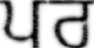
ਪਰ
